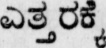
ಎತ್ತರಕ್ಕೆ
